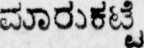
ಮಾರುಕಟ್ಟೆ
